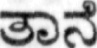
ತಾನೆ
